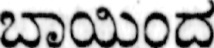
ಬಾಯಿಂದ
